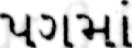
પગમાં
